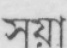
সয়া
